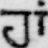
ਹਾਂ
